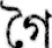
গৈ
